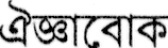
ঐজ্ঞাবোক
